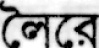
লৈরে
